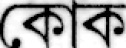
কোক
